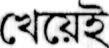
খেয়েই
